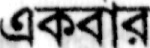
একবার
